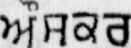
ਔਸਕਰ
